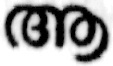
ആ
